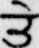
ਤੇ
